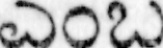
ಎಂಬ
